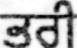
ਭਰੀ
